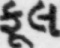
ફૂલ
